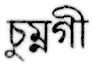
চুম্নগী
